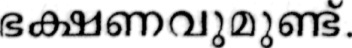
ഭക്ഷണവുമുണ്ട്.
